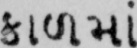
કાળમાં
